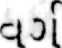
વર્ગ
